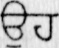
ਉਹ
